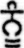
ਨੂੰ
